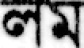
লম
